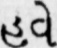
હવે
